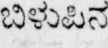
ಬಿಳುಪಿನ
